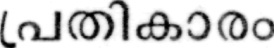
പ്രതികാരം
